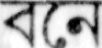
বনে
